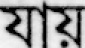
যায়
